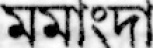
মমাংদা
